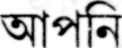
আপনি
